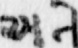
અને
